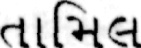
તામિલ
